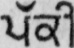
ਪੱਕੀ
